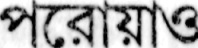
পরোয়াও
